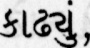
કાઢ્યું,
